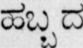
ಹಬ್ಬದ
